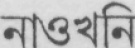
নাওখনি
